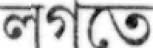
লগতে
